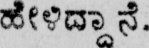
ಹೇಳಿದ್ದಾನೆ.
